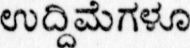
ಉದ್ದಿಮೆಗಳೂ
